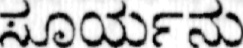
ಸೂರ್ಯನು
